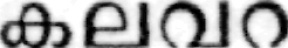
കലവറ
